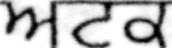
ਅਟਕ
